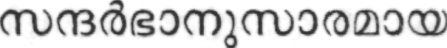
സന്ദര്‍ഭാനുസാരമായ
